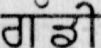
ਗੱਡੀ
